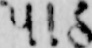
પાઠ
